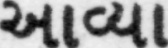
આવ્યા
